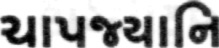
ચાપજ્યાનિ
